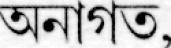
অনাগত,
